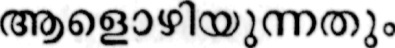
ആളൊഴിയുന്നതും
